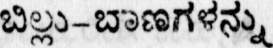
ಬಿಲ್ಲು-ಬಾಣಗಳನ್ನು
